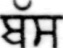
ਬੱਸ
